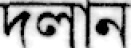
দলান
